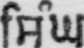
ਸਿੰਘ
